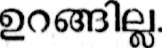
ഉറങ്ങില്ല.
